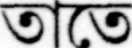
তাতে
